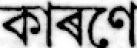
কাৰণে
